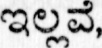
ಇಲ್ಲವೆ,
